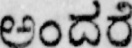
ಅಂದರೆ
